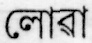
লোৱা
